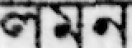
লমন
